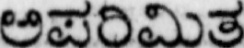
ಅಪರಿಮಿತ
